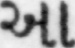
આ
